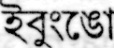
ইবুংঙো
